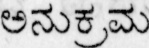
ಅನುಕ್ರಮ
